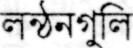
লন্ঠনগুলি
